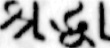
શ્રદ્ધા
